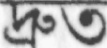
দ্রুত
